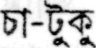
চা-টুকু
